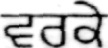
ਵਰਕੇ
